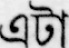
এটা
